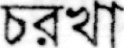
চরখা
